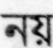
নয়
